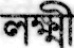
লক্ষ্মী
